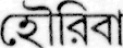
হৌরিবা
